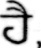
ਹੈ,
